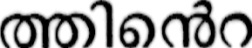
ത്തിന്റെ
